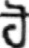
ਹੋ
